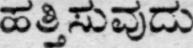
ಹತ್ತಿಸುವುದು
